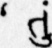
'તું
